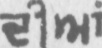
ਦੀਆਂ
